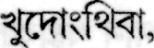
খুদোংথিবা,
